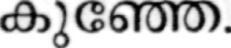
കുഞ്ഞേ.
